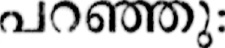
പറഞ്ഞു:
